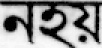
নহয়
